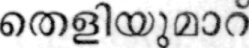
തെളിയുമാറ്
